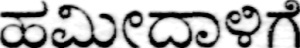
ಹಮೀದಾಳಿಗೆ
